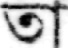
তা
